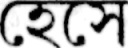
হেসে
